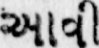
આવી
